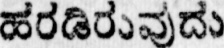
ಹರಡಿರುವುದು
